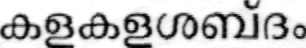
കളകളശബ്ദം
